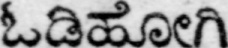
ಓಡಿಹೋಗಿ
